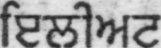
ਇਲੀਅਟ
